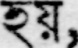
হয়,
